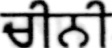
ਚੀਨੀ
